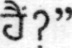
ਹੈਂ?''
